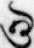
ঔ
